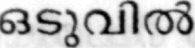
ഒടുവില്‍
